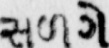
સળગે
